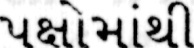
પક્ષોમાંથી
